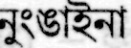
নুংঙাইনা
